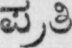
ಪ್ರತಿ
